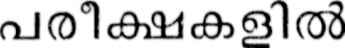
പരീക്ഷകളില്‍
